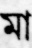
মা
